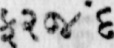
ફરજંદ
